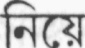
নিয়ে
